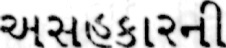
અસહકારની
